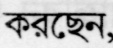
করছেন,
